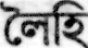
লৈহি
